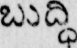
ಬುದ್ಧಿ
